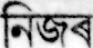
নিজৰ
